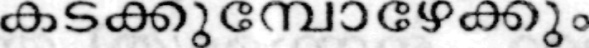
കടക്കുമ്പോഴേക്കും
